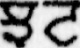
ਝਟ
